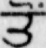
ਤੋਂ
